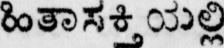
ಹಿತಾಸಕ್ತಿಯಲ್ಲಿ
